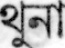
থুনা
